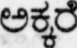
ಅಕ್ಕರೆ
